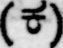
(ಕ)
